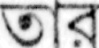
তার
